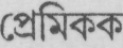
প্ৰেমিকক
